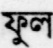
ফুল
